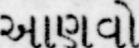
આણવો
